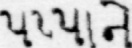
પપ્પાને
